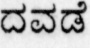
ದವಡೆ
